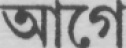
আগে
